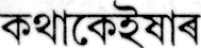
কথাকেইষাৰ
